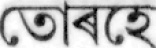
তোৰহে
